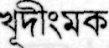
খূদীংমক
